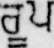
ਰੂਪ
